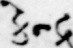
કેન્દ્ર
